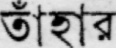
তাঁহার
